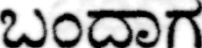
ಬಂದಾಗ
